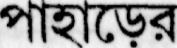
পাহাড়ের
